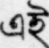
এই
